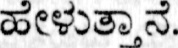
ಹೇಳುತ್ತಾನೆ.
